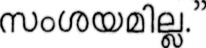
സംശയമില്ല."
